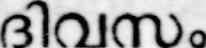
ദിവസം
